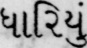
ધારિયું
